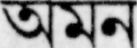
অমন
